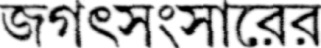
জগত্সংসারের
